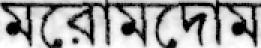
মরোমদোম
